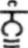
ਨੂੰ
